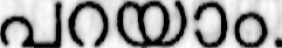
പറയാം.
